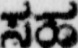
ಸಹ
